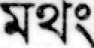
মথং
